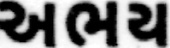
અભય
